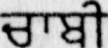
ਚਾਬੀ
